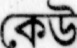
কেউ
